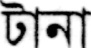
টানা
